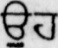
ਉਹ
